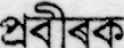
প্রবীৰক
